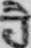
ਹੈ
